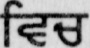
ਵਿਚ
